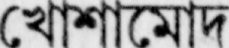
খোশামোদ
